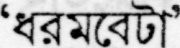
‘ধরমবেটা’
